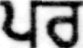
ਪਰ
